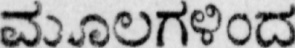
ಮೂಲಗಳಿಂದ
